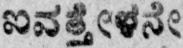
ಐವತ್ತೇಳನೇ
